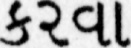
કરવા
